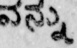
ವನ್ನು
